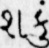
શકું
